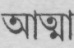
আত্মা
